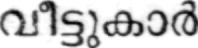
വീട്ടുകാര്‍
